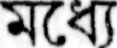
মধ্যে
